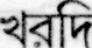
খরদি
